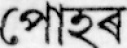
পোহৰ
